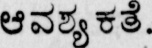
ಆವಶ್ಯಕತೆ.
